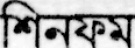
শিনফম
